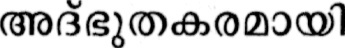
അദ്ഭുതകരമായി
